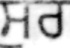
ਸੁਰ
